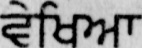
ਵੇਖਿਆ
